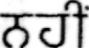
ਨਹੀਂ
